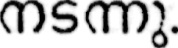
നടന്നു.
